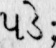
પડે;
